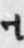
ન
